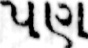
પણ
